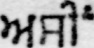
ਅਸੀਂ
